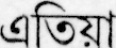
এতিয়া
